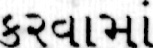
કરવામાં
